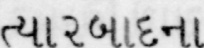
ત્યારબાદના
